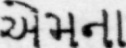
એમનાં
